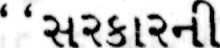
"સરકારની
